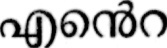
എന്റെ
